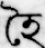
হৈ
